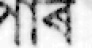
পাৰ
